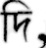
দি,
